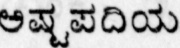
ಅಷ್ಟಪದಿಯ
